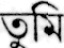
তুমি
